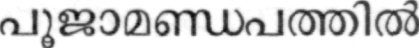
പൂജാമണ്ഡപത്തില്‍
